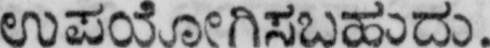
ಉಪಯೋಗಿಸಬಹುದು.
